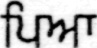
ਪਿਆ
